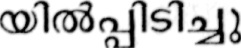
യില്‍പ്പിടിച്ചു
